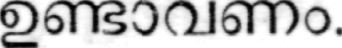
ഉണ്ടാവണം.
